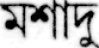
মশাদু
